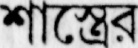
শাস্ত্রের
